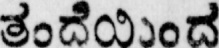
ತಂದೆಯಿಂದ
